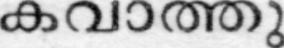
കവാത്തു
